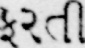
ફરતી
